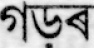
গড়ৰ
